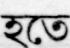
হতে
